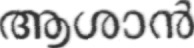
ആശാന്‍
